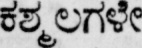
ಕಶ್ಮಲಗಳೇ
